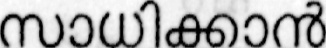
സാധിക്കാന്‍
